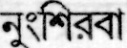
নুংশিরবা
